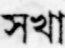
সখা
